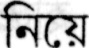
নিয়ে
